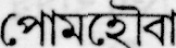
পোমহৌবা
